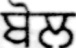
ਬੋਲ
